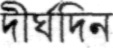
দীর্ঘদিন
